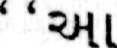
"આ
